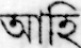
আহি
